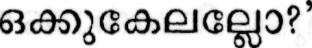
ഒക്കുകേലല്ലോ?’
